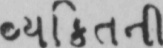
વ્યક્તિની
